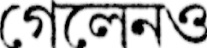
গেলেনও
